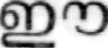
ഈ
